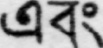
এবং
